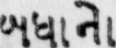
બધાનો
